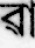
ৱা
